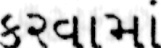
કરવામાં
